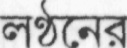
লণ্ঠনের
